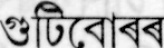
গুটিবোৰৰ
